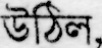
উঠিল,
